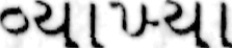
વ્યાખ્યા
